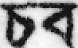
চব
